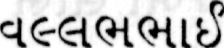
વલ્લભભાઈ
